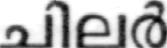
ചിലര്‍
